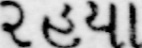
રહયા
